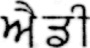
ਐਡੀ
